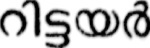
റിട്ടയര്‍
